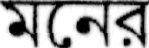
মনের
